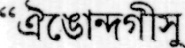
“ঐঙোন্দগীসু
